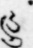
હું
